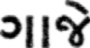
ગાજે
